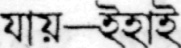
যায়—ইহাই
